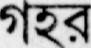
গহর
